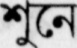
শুনে
